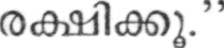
രക്ഷിക്കൂ."
